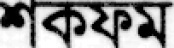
শকফম
